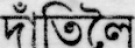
দাঁতিলৈ
